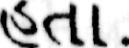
હતા.
